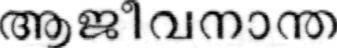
ആജീവനാന്ത
